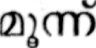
മൂന്ന്
